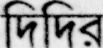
দিদির
